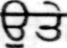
ਉਤੇ
